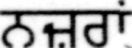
ਨਜ਼ਰਾਂ
